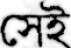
সেই
